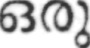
ഒരു
